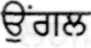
ਉਂਗਲ
